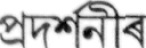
প্রদৰ্শনীৰ
